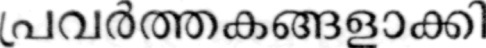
പ്രവര്‍ത്തകങ്ങളാക്കി
